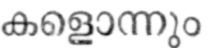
കളൊന്നും
